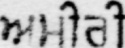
ਅਮੀਰੀ
